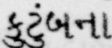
કુટુંબના
